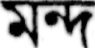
মন্দ
